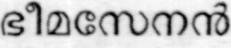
ഭീമസേനന്‍
